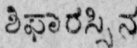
ಶಿಫಾರಸ್ಸಿನ
